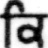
ਕਿ
